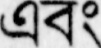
এবং
